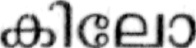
കിലോ
